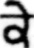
ਕੇ
